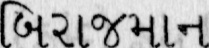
બિરાજમાન
